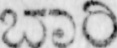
ಬಾರಿ
